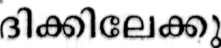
ദിക്കിലേക്കു
